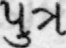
પુત્ર
